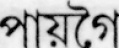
পায়গৈ
